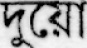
দুয়ো
